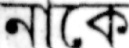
নাকে
